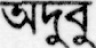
অদুবু
